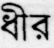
ধীর
